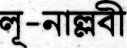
লূ-নাল্লবী
